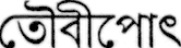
তৌবীপোৎ
